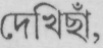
দেখিছাঁ,
